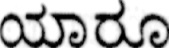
ಯಾರೂ
